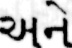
અને
